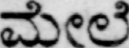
ಮೇಲೆ
